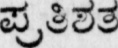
ಪ್ರತಿಶತ
